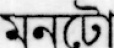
মনটো
